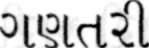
ગણતરી
